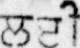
ਲਈ
